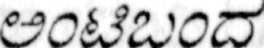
ಅಂಟಿಬಂದ
